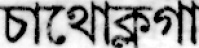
চাথোক্লগা
